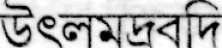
উৎলমদ্রবদি
